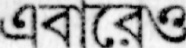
এবারেও
